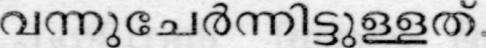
വന്നുചേര്‍ന്നിട്ടുള്ളത്.
